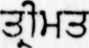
ਤ੍ਰੀਮਤ
